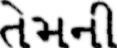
તેમની
